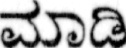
ಮಾಡಿ
